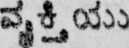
ವ್ಯಕ್ತಿಯು
